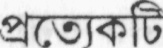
প্রত্যেকটি
